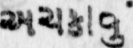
અચકાવું
